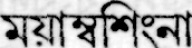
ময়াম্বশিংনা
